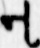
ન
